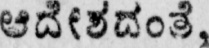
ಆದೇಶದಂತೆ,
